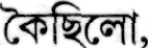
কৈছিলো,
